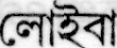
লোইবা
